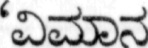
‘ವಿಮಾನ
